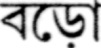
বড়ো
